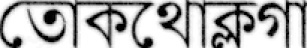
তোকথোক্লগা
